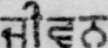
ਜੀਵਨ
